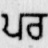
ਪਰ
